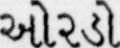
ઓરડો
